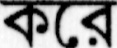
করে
